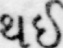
થઈ
